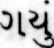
ગયું
